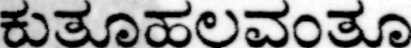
ಕುತೂಹಲವಂತೂ
